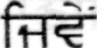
ਜਿਵੇਂ
